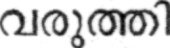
വരുത്തി
